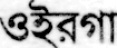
ওইরগা
